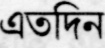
এতদিন
